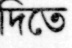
দিতে
